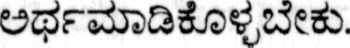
ಅರ್ಥಮಾಡಿಕೊಳ್ಳಬೇಕು.
